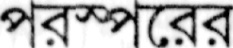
পরস্পরের
